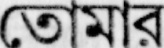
তোমার
